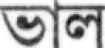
ভাল
